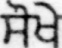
ਸੌਖੇ
